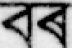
বৰ
